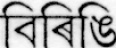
বিৰিঙি
